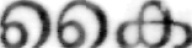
കൈ
